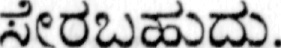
ಸೇರಬಹುದು.
